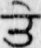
ਤੇ
